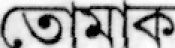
তোমাক
